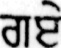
ਗਏ
